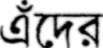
এঁদের
